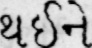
થઈને
